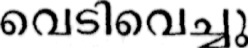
വെടിവെച്ചു
